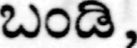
ಬಂಡಿ,
